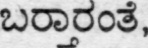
ಬರ್‍ತಾರ೦ತೆ.
